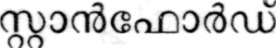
സ്റ്റാന്‍ഫോര്‍ഡ്
